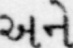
અને
